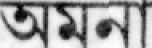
অমনা
